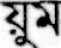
য়ুম
